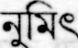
নুমিৎ
